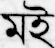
মই
